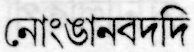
নোংঙানবদদি
